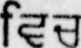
ਵਿਚ
